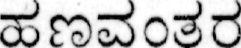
ಹಣವಂತರ
